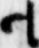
ન
